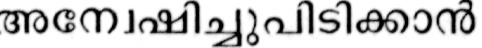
അന്വേഷിച്ചുപിടിക്കാന്‍
